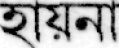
হায়না
